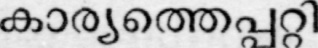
കാര്യത്തെപ്പറ്റി
